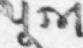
પૂજા
